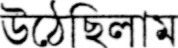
উঠেছিলাম
